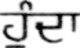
ਹੁੰਦਾ
